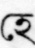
হে
